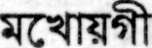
মখোয়গী
